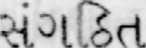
સંગઠિત
